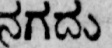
ನಗದು
